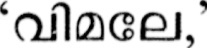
‘വിമലേ,’
